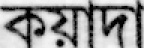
কয়াদা
